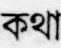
কথা
